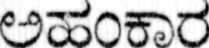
ಅಹಂಕಾರ
